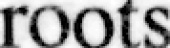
roots
